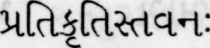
પ્રતિકૃતિસ્તવનઃ
